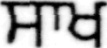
ਸਾਖ
